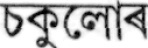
চকুলোৰ
